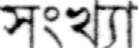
সংখ্যা
